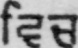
ਵਿਚ
